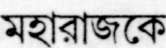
মহারাজকে
